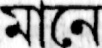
মানে
